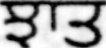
ਝਾਤ
